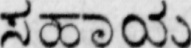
ಸಹಾಯ
